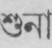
শুনা
